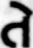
તે
